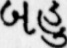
બહુ
